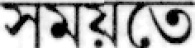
সময়তে
